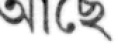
আছে
